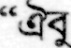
“ঐবু
